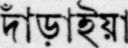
দাঁড়াইয়া
